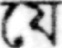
যে
